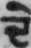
ਦੇ
